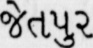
જેતપુર
